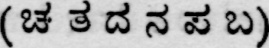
(ಚತದನಪಬ)
